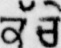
ਕੱਚੇ
